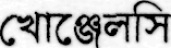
খোঞ্জেলসি
